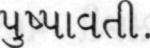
પુષ્પાવતી.
